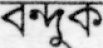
বন্দুক
